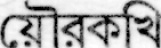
য়ৌরকখি
